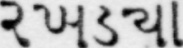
રખડ્યા
